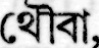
থৌবা,
